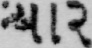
ચાર
